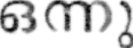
ഒന്നു
